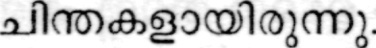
ചിന്തകളായിരുന്നു.
